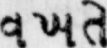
વખતે
